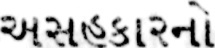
અસહકારનો
